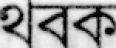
থবক
